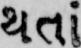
થતાં
